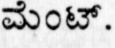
ಮೆಂಟ್.
